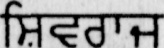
ਸ਼ਿਵਰਾਜ
